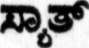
ಸ್ಯಾತ್
